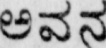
ಅವನ
